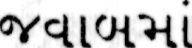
જવાબમાં
